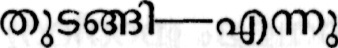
തുടങ്ങി-എന്നു
